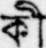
কী
